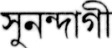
সুনন্দাগী
